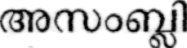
അസംബ്ലി
